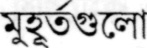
মুহূর্তগুলো
